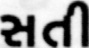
સતી
